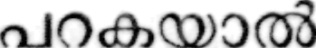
പറകയാല്‍
